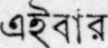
এইবার
